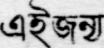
এইজন্য
